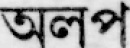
অলপ
